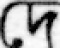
দে
